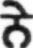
ਨੇ
